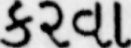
કરવા
